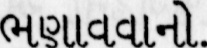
ભણાવવાનો.
